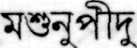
মশুনুপীদু
